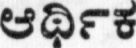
ಆರ್ಥಿಕ
